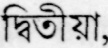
দ্বিতীয়া,
